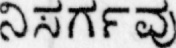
ನಿಸರ್ಗವು
